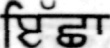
ਇੱਛਾ
